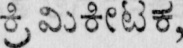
ಕ್ರಿಮಿಕೀಟಕ,
